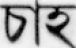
চাহ
